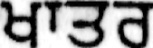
ਖਾਤਰ
